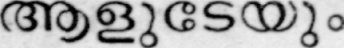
ആളുടേയും
